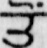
ਤੋਂ
